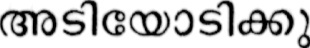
അടിയോടിക്കു
